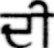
ਦੀ
